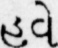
હવે
